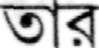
তার
